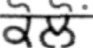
ਕੋਲੋਂ
